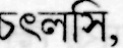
চৎলসি,
